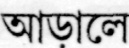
আড়ালে
